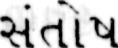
સંતોષ
